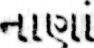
નાણાં
